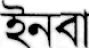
ইনবা
